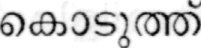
കൊടുത്ത്
